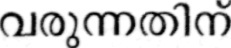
വരുന്നതിന്
